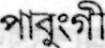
পাবুংগী
